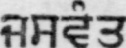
ਜਸਵੰਤ
